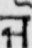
ਜੋ
